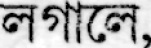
লগালে,
